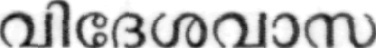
വിദേശവാസ
